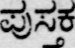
ಪುಸ್ತಕ
